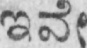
ಇವೇ
